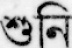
শুনি
